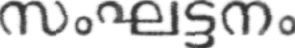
സംഘട്ടനം
